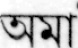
অমা
